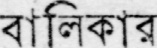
বালিকার
